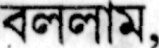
বললাম,
